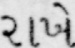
રાખે
